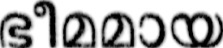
ഭീമമായ
